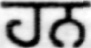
ਹਨ
